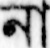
না
